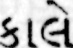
કાલે
